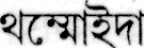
থম্মোইদা
